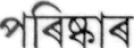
পৰিষ্কাৰ
